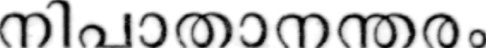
നിപാതാനന്തരം
